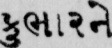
કુભારને
